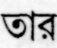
তার
